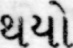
થયો
